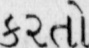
કરતો
